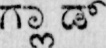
ಗ್ಲಾಡ್
